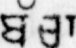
ਬੱਚਾ
